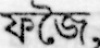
ফজৈ,
